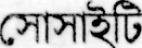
সোসাইটি
